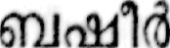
ബഷീര്‍
